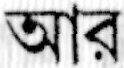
আর
